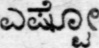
ಎಷ್ಟೋ
